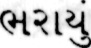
ભરાયું
